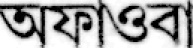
অফাওবা
